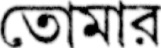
তোমার
